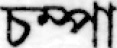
চম্পা
